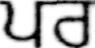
ਪਰ
